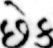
છેક
